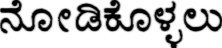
ನೋಡಿಕೊಳ್ಳಲು
